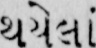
થયેલાં
